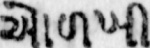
ઓળખી
